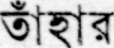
তাঁহার
